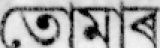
তোমাৰ
